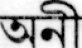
অনী
